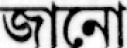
জানো
